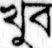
খুব
